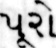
પૂરો
